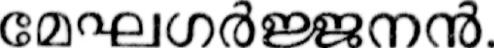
മേഘഗര്‍ജ്ജനന്‍.
